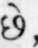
છે,
